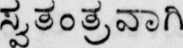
ಸ್ವತಂತ್ರವಾಗಿ
